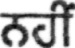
ਨਹੀਂ
